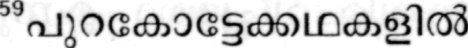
59പുറകോട്ടേക്കഥകളില്‍
